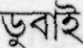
ডুবাই
